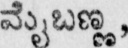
ಮೈಬಣ್ಣ,
